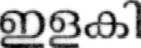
ഇളകി
